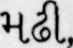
મઢી,
